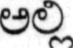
ಅಲ್ಲಿ
